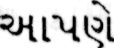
આપણે
